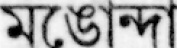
মঙোন্দা
